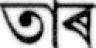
তাৰ
